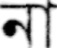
না
